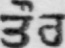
ਤੌਰ
